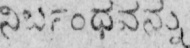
ನಿರ್ಬಂಧವನ್ನು
